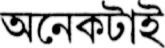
অনেকটাই
